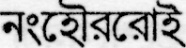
নংহৌররোই
